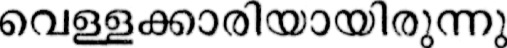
വെള്ളക്കാരിയായിരുന്നു
